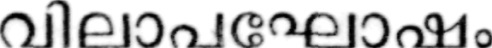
വിലാപഘോഷം
